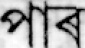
পাৰ
